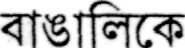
বাঙালিকে
